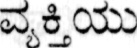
ವ್ಯಕ್ತಿಯು
